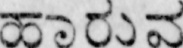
ಹಾರುವ
